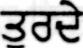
ਤੁਰਦੇ
